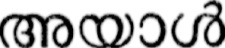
അയാള്‍
